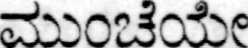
ಮುಂಚೆಯೇ
